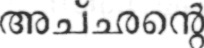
അച്ഛന്റെ
